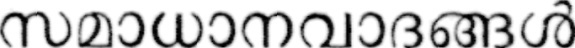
സമാധാനവാദങ്ങള്‍
